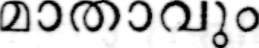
മാതാവും
